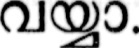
വയ്യാ.
